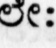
ಲೇ:
